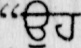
''ਉਹ
